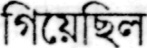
গিয়েছিল
